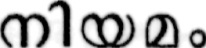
നിയമം
